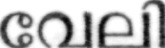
വേലി
